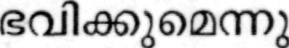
ഭവിക്കുമെന്നു
